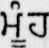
ਮੂੰਹ
